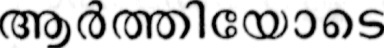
ആര്‍ത്തിയോടെ
